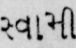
સ્વામી
